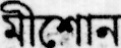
মীশোন
